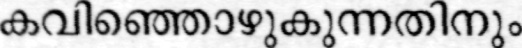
കവിഞ്ഞൊഴുകുന്നതിനും
